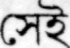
সেই
